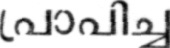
പ്രാപിച്ച
